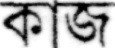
কাজ
